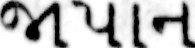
જાપાન
